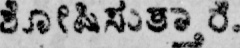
ಶೋಷಿಸುತ್ತಾರೆ.
